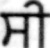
ਸੀ
